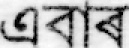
এবাৰ
